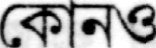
কোনও
